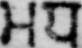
ਮਧ
